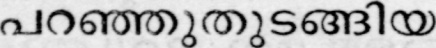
പറഞ്ഞുതുടങ്ങിയ
